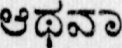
ಆಥವಾ
